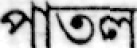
পাতল
